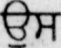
ਉਸ
